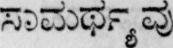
ಸಾಮರ್ಥ್ಯವು
